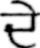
ਦੇ
